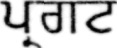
ਪ੍ਰਗਟ
